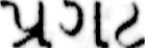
પ્રગટ
